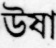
উষা
